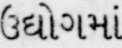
ઉધોગમાં
